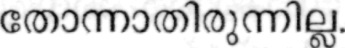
തോന്നാതിരുന്നില്ല.
